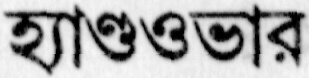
হ্যাণ্ডওভার
